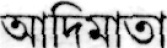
আদিমাতা
